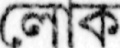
লোক
